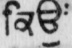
ਕਿਉਂ
